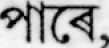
পাৰে,
